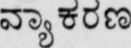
ವ್ಯಾಕರಣ
